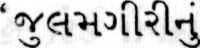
'જુલમગીરીનું
